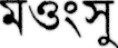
মওংসু
